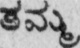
ತಮ್ಮ
